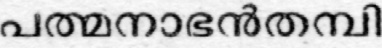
പത്മനാഭന്‍തമ്പി
